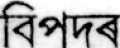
বিপদৰ
